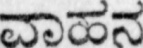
ವಾಹನ
